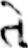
તે
